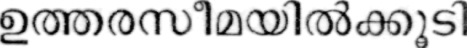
ഉത്തരസീമയില്‍ക്കൂടി
